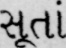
સૂતાં
